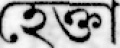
হেক্তা
